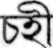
চহী
